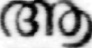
ആ
